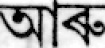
আৰু
